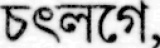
চৎলগে,
